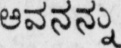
ಅವನನ್ನು
